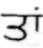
ਤਾਂ
